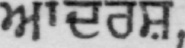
ਆਦਰਸ਼,
